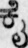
ಕೈ
